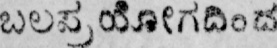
ಬಲಪ್ರಯೋಗದಿಂದ
